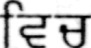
ਵਿਚ
